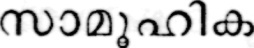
സാമൂഹിക
